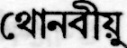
থোনবীয়ু
